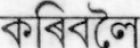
কৰিবলৈ
